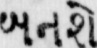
બનશે
